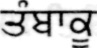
ਤੰਬਾਕੂ
